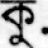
কু.
